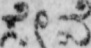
ಸೇವೆ
